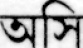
অসি
